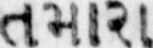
તમારા
